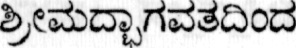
ಶ್ರೀಮದ್ಭಾಗವತದಿಂದ
